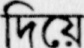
দিয়ে
